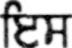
ਇਸ
